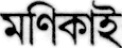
মণিকাই
